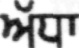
ਅੱਧਾ
